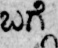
ಬಗ್ಗೆ
